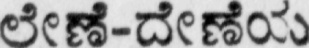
ಲೇಣೆ-ದೇಣೆಯ
